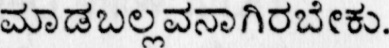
ಮಾಡಬಲ್ಲವನಾಗಿರಬೇಕು.
